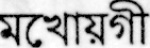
মখোয়গী
